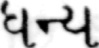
ધન્ય
